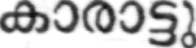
കാരാട്ടു
